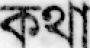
কথা
